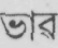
ভাৱ
